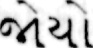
જોયો
